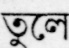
তুলে
